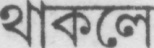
থাকলে
